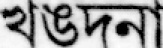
খঙদনা
